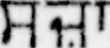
ਸਜ਼ਾ
